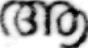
ആ
